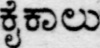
ಕೈಕಾಲು
